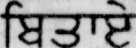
ਬਿਤਾਏ
